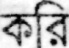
করি
